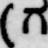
(ಗ
